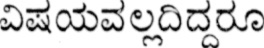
ವಿಷಯವಲ್ಲದಿದ್ದರೂ
